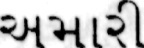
અમારી
